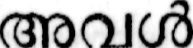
അവള്‍
